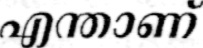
എന്താണ്
